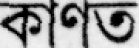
কাণত
